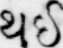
થઈ
